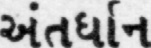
અંતર્ધાન
